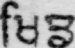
ਖਿਡ
